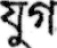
যুগ
